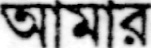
আমার
